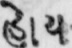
હોય
